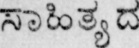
ಸಾಹಿತ್ಯದ
